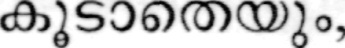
കൂടാതെയും,
